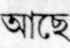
আছে
